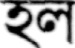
হল
